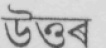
উত্তৰ
